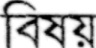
বিষয়
